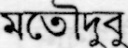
মতৌদুবু
